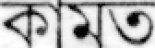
কামত
